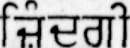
ਜ਼ਿੰਦਗੀ
